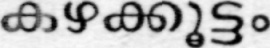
കഴക്കൂട്ടം
